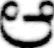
ಆ
